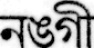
নঙগী
